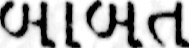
બાબત
